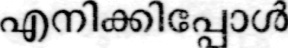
എനിക്കിപ്പോള്‍
